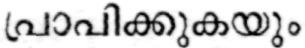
പ്രാപിക്കുകയും
